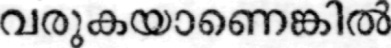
വരുകയാണെങ്കില്‍
